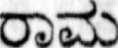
ರಾಮ
